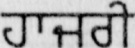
ਹਾਜਰੀ
